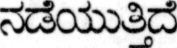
ನಡೆಯುತ್ತಿದೆ
